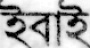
ইবাই
